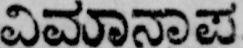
ವಿಮಾನಾಪ
